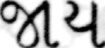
જાય
